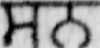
ਸਨ
